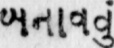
બનાવવું
